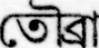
তৌব্রা
